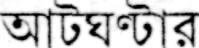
আটঘণ্টার
